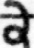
ਕੇ
